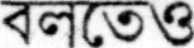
বলতেও
